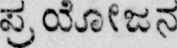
ಪ್ರಯೋಜನ
